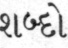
શબ્દો
